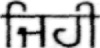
ਜਿਹੀ
